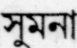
সুমনা
